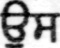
ਉਸ
